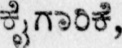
ಕೈಗಾರಿಕೆ,
